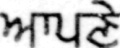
ਆਪਣੇ
